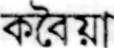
কবৈয়া
